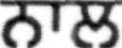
ਨਾਲ
